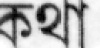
কথা
